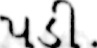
પડી.
